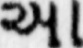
આ
